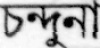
চন্দুনা
